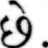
છે.
